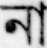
না
